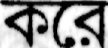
করে
